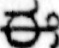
ಈ
